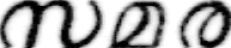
സമര
